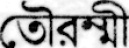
তৌরম্মী
